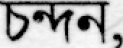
চন্দন,
